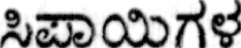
ಸಿಪಾಯಿಗಳ
